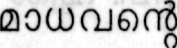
മാധവന്റെ
